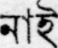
নাই
